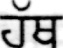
ਹੱਥ
